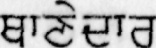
ਥਾਣੇਦਾਰ
